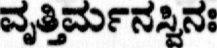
ವೃತ್ತಿರ್ಮನಸ್ವಿನಃ
